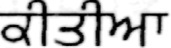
ਕੀਤੀਆਂ
